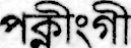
পক্নীংগী
